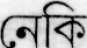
নেকি
